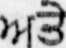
ਅਤੇ
